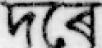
দৰে
